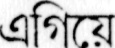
এগিয়ে
